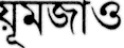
য়ূমজাও
